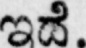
ಇದೆ.
